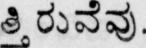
ತ್ತಿರುವೆವು.
